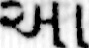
આ
